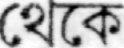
থেকে
